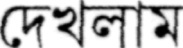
দেখলাম
